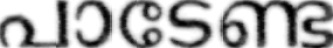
പാടേണ്ട
